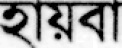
হায়বা
